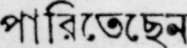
পারিতেছেন
